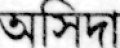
অসিদা
